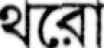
থরো
